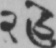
રહે
